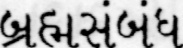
બ્રહ્મસંબંધ
